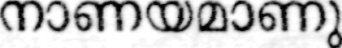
നാണയമാണു
